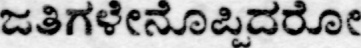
ಜತಿಗಳೇನೊಪ್ಪಿದರೋ
